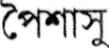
পৈশাসু
